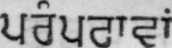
ਪਰੰਪਰਾਵਾਂ
